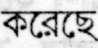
করেছে
